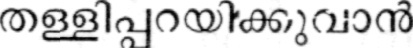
തള്ളിപ്പറയിക്കുവാന്‍
